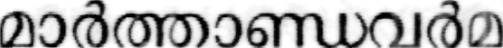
മാര്‍ത്താണ്ഡവര്‍മ
